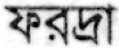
ফরদ্রা
